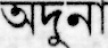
অদুনা
